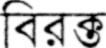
বিরক্ত
